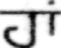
ਹਾਂ
